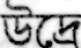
উদ্রে
